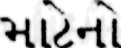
માટેનો
